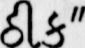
ઠીક"
